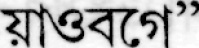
য়াওবগে”
